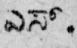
ಎಸ್.
